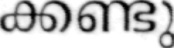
ക്കണ്ടു
